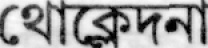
থোক্লেদনা
